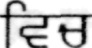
ਵਿਚ
